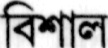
বিশাল
